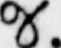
જ.
